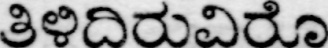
ತಿಳಿದಿರುವಿರೊ
